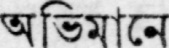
অভিমানে
